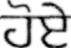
ਹੋਏ
